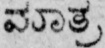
ಮಾತ್ರ
